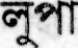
লুপা
